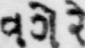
વગેરે
